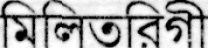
মিলিতরিগী
